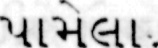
પામેલા.
